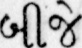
બીજે
